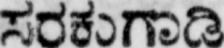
ಸರಕುಗಾಡಿ
